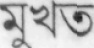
মুখত
